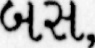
બસ,
